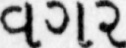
વગર
